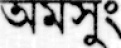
অমসুং
